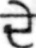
ਦੇ
